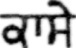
ਕਾਸੇ
